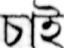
চাই
